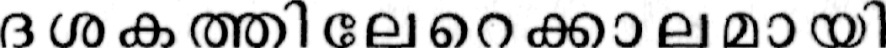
ദശകത്തിലേറെക്കാലമായി
